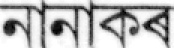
নানাকৰ
